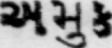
અમુક
